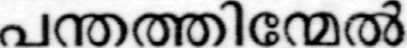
പന്തത്തിന്മേല്‍
